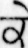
ਕੇ
